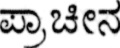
ಪ್ರಾಚೀನ
